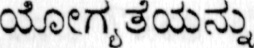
ಯೋಗ್ಯತೆಯನ್ನು
